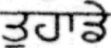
ਤੁਹਾਡੇ
